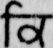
ਕਿ
